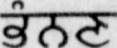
ਭੰਨਣ
